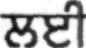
ਲਈ
